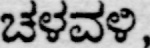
ಚಳವಳಿ,
